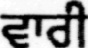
ਵਾਰੀ
